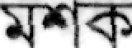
মশক
